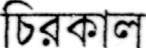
চিরকাল
